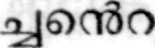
ച്ചന്റെ
